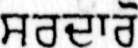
ਸਰਦਾਰੋ
